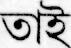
তাই
